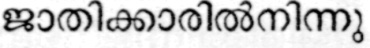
ജാതിക്കാരില്‍നിന്നു
